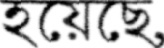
হয়েছে,
